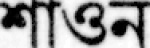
শাওন
